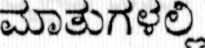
ಮಾತುಗಳಲ್ಲಿ
